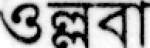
ওল্লবা
